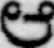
ಆ
